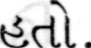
હતો.
